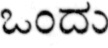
ಒಂದು
